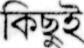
কিছুই
